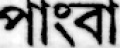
পাংবা
